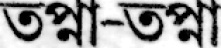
তপ্না-তপ্না
